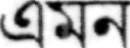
এমন
